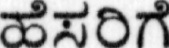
ಹೆಸರಿಗೆ
